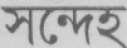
সন্দেহ
